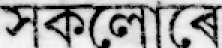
সকলোৰে
